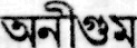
অনীগুম
